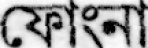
ফোংনা
